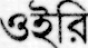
ওইরি
